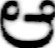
ಆ
